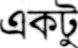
একটু
